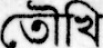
তৌখি
